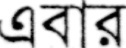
এবার
